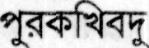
পুরকখিবদু
